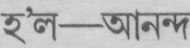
হ'ল-আনন্দ
